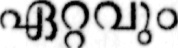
ഏറ്റവും
